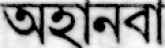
অহানবা
